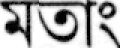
মতাং
